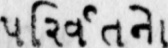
પરિવર્તનો
